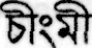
চীংমী
